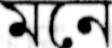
মনে
